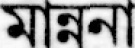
মান্ননা
